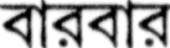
বারবার
